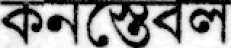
কনস্তেবল
